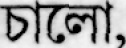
চালো,
